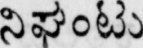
ನಿಘಂಟು
